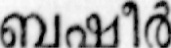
ബഷീര്‍
